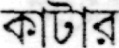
কাটার
